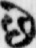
છે
